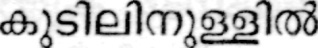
കുടിലിനുള്ളില്‍
